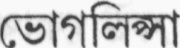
ভোগলিপ্সা
